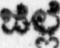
ಜಿಲ್ಲೆ
